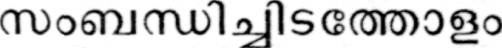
സംബന്ധിച്ചിടത്തോളം
